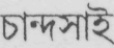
চান্দসাই
